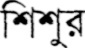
শিশুর
